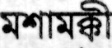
মশামক্কী
